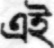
এই
